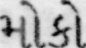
મોકો
